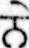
ਨੇ
